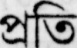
প্রতি
